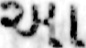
આ
